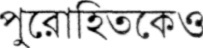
পুরোহিতকেও
